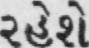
રહેશે
